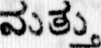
ಮತ್ತು
